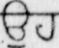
ਉਹ
